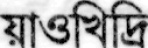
য়াওখিদ্রি
